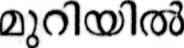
മുറിയില്‍
